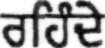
ਰਹਿੰਦੇ
